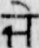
ਜੇ
